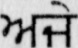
ਅਜੇ
